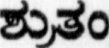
ಶ್ರುತಂ
